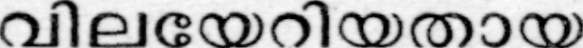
വിലയേറിയതായ
